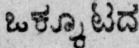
ಒಕ್ಕೂಟದ
